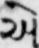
એ
